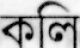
কলি
